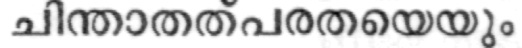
ചിന്താതത്പരതയെയും
